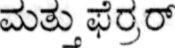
ಮತ್ತುಫೆರ್ರರ್
